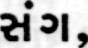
સંગ,
